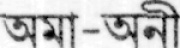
অমা-অনী
